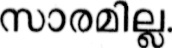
സാരമില്ല.
